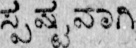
ಸ್ಪಷ್ಟವಾಗಿ
